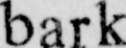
bark
